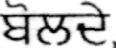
ਬੋਲਦੇ,
